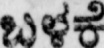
ಬಳಕೆ
